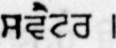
ਸਵੈਟਰ।
